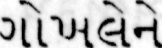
ગોખલેને
